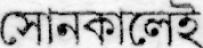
সোনকালেই
